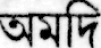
অমদি
